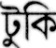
টুকি
